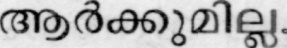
ആര്‍ക്കുമില്ല.
